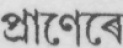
প্রাণেৰে
